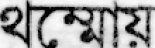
থম্মোয়
